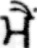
ਮੈਂ
